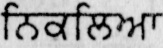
ਨਿਕਲਿਆ
